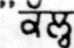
''ਕੱਲ੍ਹ
